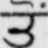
ਤੋਂ
